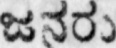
ಜನರು
